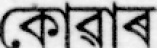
কোৱাৰ
